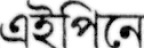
এইপিনে
